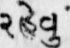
રહેવું
